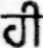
ਹੀ
